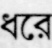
ধরে
